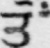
ਤੋਂ
